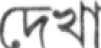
দেখা
